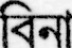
বিনা
